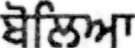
ਬੋਲਿਆ
